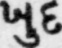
ખુદ
